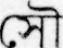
সৌ
